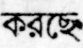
করছে
